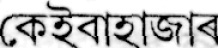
কেইবাহাজাৰ
